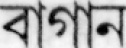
বাগান
